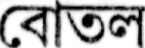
বোতল
